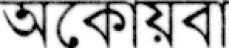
অকোয়বা
